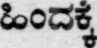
ಹಿಂದಕ್ಕೆ
